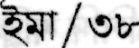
ইমা/৩৮
